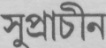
সুপ্ৰাচীন
